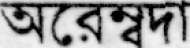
অরেম্বদা
